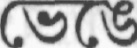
ভেঙে
